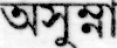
অসুম্না
